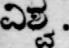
ವಿಶ್ವ.
